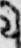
યે
